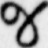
જ
